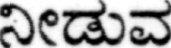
ನೀಡುವ
